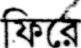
ফিরে
